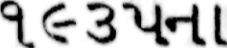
૧૯૩૫ના
